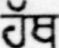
ਹੱਥ
